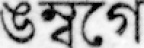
ঙম্বগে
